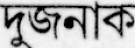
দুজনাক
